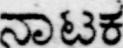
ನಾಟಕ
